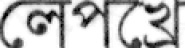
লেপখ্রে
